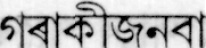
গৰাকীজনবা
